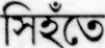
সিহঁতে
